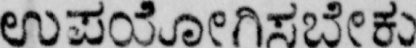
ಉಪಯೋಗಿಸಬೇಕು
